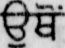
ਉਥੋਂ
